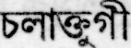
চলাক্তুগী
